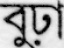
বুঢ়া
